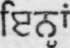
ਇਨ੍ਹਾਂ
